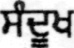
ਸੰਦੂਖ
